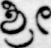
ಶ್ರೀ
